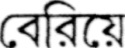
বেরিয়ে
